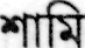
শামি
